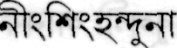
নীংশিংহন্দুনা
